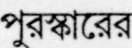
পুরস্কারের
